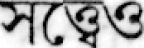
সত্ত্বেও
